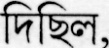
দিছিল,
